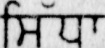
ਸਿੱਧਾ
